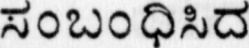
ಸಂಬಂಧಿಸಿದ
